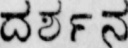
ದರ್ಶನ
